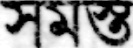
সমস্ত
